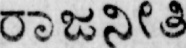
ರಾಜನೀತಿ
